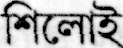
শিলোই
